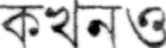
কখনও
